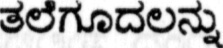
ತಲೆಗೂದಲನ್ನು
